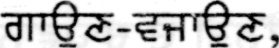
ਗਾਉਣ-ਵਜਾਉਣ,
